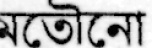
মতৌনো
